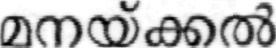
മനയ്ക്കല്‍
